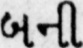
બની
